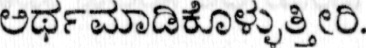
ಅರ್ಥಮಾಡಿಕೊಳ್ಳುತ್ತೀರಿ.
